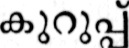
കുറുപ്പ്
